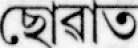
ছোৱাত
